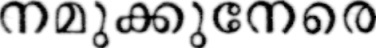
നമുക്കുനേരെ
